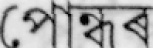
পোন্ধৰ
